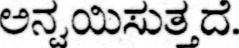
ಅನ್ವಯಿಸುತ್ತದೆ.
